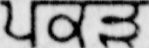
ਪਕੜ
